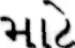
માટે
